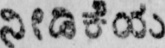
ನೀಡಿಕೆಯ
